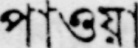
পাওয়া
